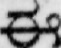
ಈ
